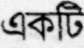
একটি
